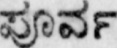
ಪೂರ್ವ
